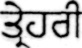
ਤ੍ਰੇਹਰੀ
